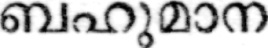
ബഹുമാന
